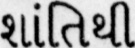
શાંતિથી
